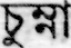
চুম্না
